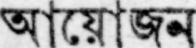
আয়োজন
